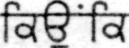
ਕਿਉਂਕਿ
